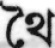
থৈ
